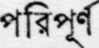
পরিপূর্ণ
